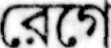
রেগে
